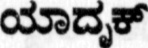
ಯಾದೃಕ್
